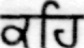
ਕਹਿ
